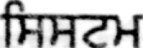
ਸਿਸਟਮ
